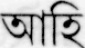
আহি
